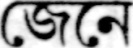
জেনে
